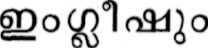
ഇംഗ്ലീഷും
